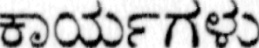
ಕಾರ್ಯಗಳು
